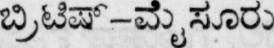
ಬ್ರಿಟಿಷ್-ಮೈಸೂರು
